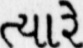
ત્યારે
